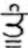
ਤੂੰ
